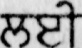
ਲਈ
